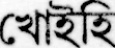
খোইহি
